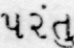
પરંતુ
